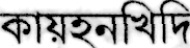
কায়হনখিদি
